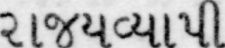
રાજ્યવ્યાપી
